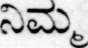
ನಿಮ್ಮ
